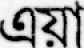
এয়া
